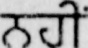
ਨਹੀਂ
